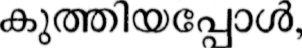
കുത്തിയപ്പോള്‍,
